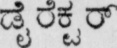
ಡೈರೆಕ್ಟರ್
